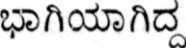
ಭಾಗಿಯಾಗಿದ್ದ
